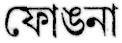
ফোঙনা
